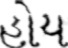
હોય
